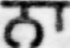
ਨਾ
